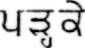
ਪੜ੍ਹਕੇ
